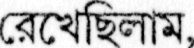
রেখেছিলাম,
